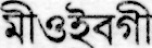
মীওইবগী
